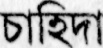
চাহিদা
